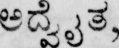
ಅದ್ವೈತ,
